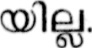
യില്ല.
